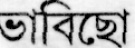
ভাবিছো
